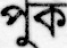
পুক
